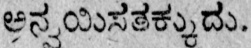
ಅನ್ವಯಿಸತಕ್ಕುದು.
